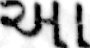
આ
